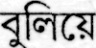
বুলিয়ে
